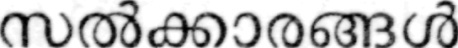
സല്‍ക്കാരങ്ങള്‍
